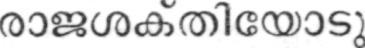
രാജശക്തിയോടു
